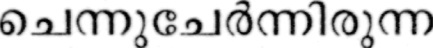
ചെന്നുചേര്‍ന്നിരുന്ന
